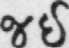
જઈ
